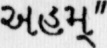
અહમ્"
